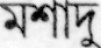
মশাদু
